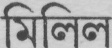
মিলিল
